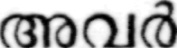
അവര്‍
